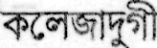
কলেজাদুগী
